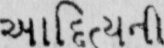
આદિત્યની
